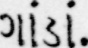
ગાંડાં.
